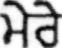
ਮੇਰੇ
